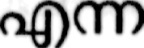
എന്ന
